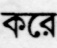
করে
